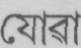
যোৱা
